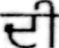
ਦੀ
